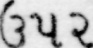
ઉપર
